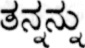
ತನ್ನನ್ನು
